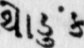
થોડુંક
